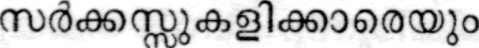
സര്‍ക്കസ്സുകളിക്കാരെയും
